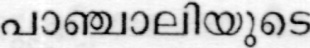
പാഞ്ചാലിയുടെ
